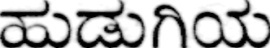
ಹುಡುಗಿಯ
